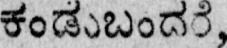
ಕಂಡುಬಂದರೆ,
